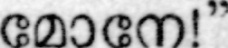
മോനേ!”
